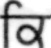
ਕਿ
